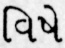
વિષે
